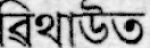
ৱিথাউত
